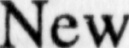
New
